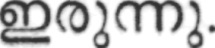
ഇരുന്നു.
